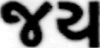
જય
